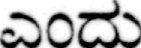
ಎಂದು
